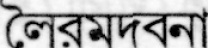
লৈরমদবনা
